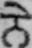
ਨੇ
